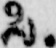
ಸಿ.
